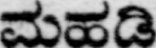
ಮಹಡಿ
